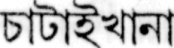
চাটাইখানা
